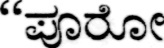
"ಪೂರೋ
